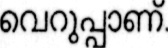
വെറുപ്പാണ്.
